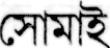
সোমাই
